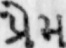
પ્રેમ
